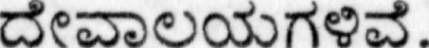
ದೇವಾಲಯಗಳಿವೆ.
